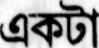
একটা
